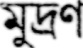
মুদ্রণ
